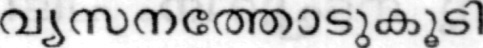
വ്യസനത്തോടുകൂടി
